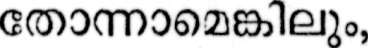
തോന്നാമെങ്കിലും,
